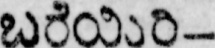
ಬರೆಯಿರಿ-
